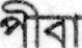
পীবা
